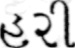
હરી
